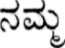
ನಮ್ಮ
